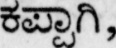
ಕಪ್ಪಾಗಿ,
